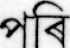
পৰি
